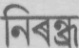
নিৰন্ধ্ৰ
